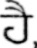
ਹੈ,
